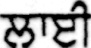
ਲਾਈ
